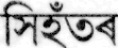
সিহঁতৰ
